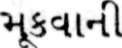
મૂકવાની
